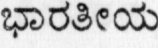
ಭಾರತೀಯ
